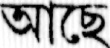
আছে
